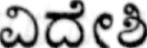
ವಿದೇಶಿ
